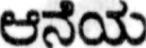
ಆನೆಯ
